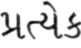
પ્રત્યેક
